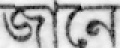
জানে
